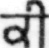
ਕੀ
